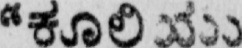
“ಕೂಲಿಯು
